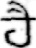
ਹੈ
